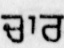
ਚਾਰ
